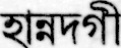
হান্নদগী
